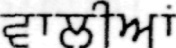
ਵਾਲੀਆਂ
